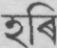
হৰি
